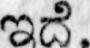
ಇದೆ.
